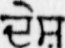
ਦੇਸ਼
